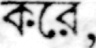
করে,
